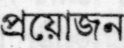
প্রয়োজন
